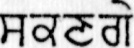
ਸਕਣਗੇ
